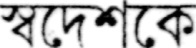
স্বদেশকে
